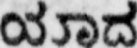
ಯಾದ
